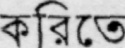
করিতে
